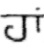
ਹਾਂ
